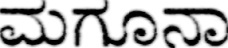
ಮಗೂನಾ
